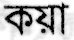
কয়া
